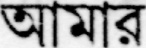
আমার
